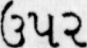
ઉપર
